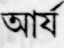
আর্য
